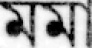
মমা
